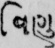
વિણુ
